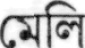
মেলি
